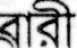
ৱারী
